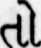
તો
